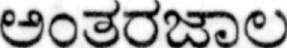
ಅಂತರಜಾಲ
